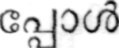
പ്പോള്‍
